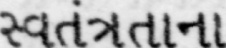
સ્વતંત્રતાના
